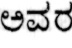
ಅವರ
